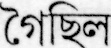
গৈছিল
